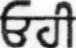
ਓਹੀ
